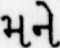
મને
